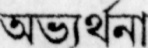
অভ্যর্থনা
